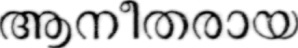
ആനീതരായ
